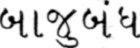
બાજુબંધ
